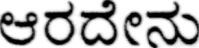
ಆರದೇನು
